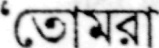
‘তোমরা
